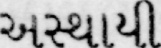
અસ્થાયી
